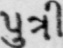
પુત્રી
